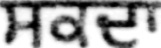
ਸਕਦਾ
